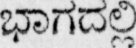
ಭಾಗದಲ್ಲಿ
